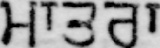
ਮਾਤਰਾ
